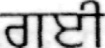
ਗਈ
